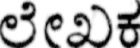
ಲೇಖಕ
